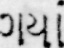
ગયાં
